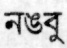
নঙবু
